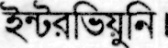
ইন্টরভিয়ুনি।
